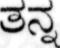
ತನ್ನ
